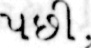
પછી,
